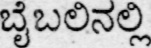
ಬೈಬಲಿನಲ್ಲಿ
